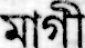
মাগী
